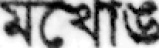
মখোঙ
